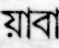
য়াবা
